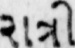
રાત્રી
